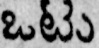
ಒಟು
